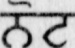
ਨੋਟ
